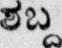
ಶಬ್ದ
